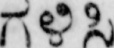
ಗಳಿಸಿ
